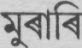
মুৰাৰি
